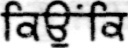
ਕਿਉਂਕਿ
